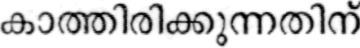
കാത്തിരിക്കുന്നതിന്
